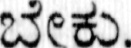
ಬೇಕು.
